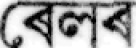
ৰেলৰ
